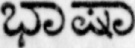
ಭಾಷಾ
